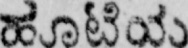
ಹೂಟೆಯ
